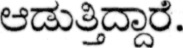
ಆಡುತ್ತಿದ್ದಾರೆ.
